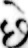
છે
